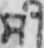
ਸੀ
